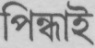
পিন্ধাই
